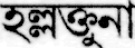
হল্লক্তুনা
